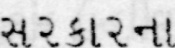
સરકારના
